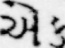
એક
